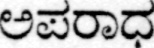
ಅಪರಾಧ
